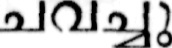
ചവച്ചു
